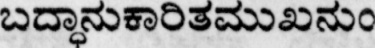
ಬದ್ಧಾನುಕಾರಿತಮುಖನುಂ
